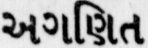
અગણિત
